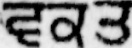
ਵਕਤ
